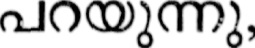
പറയുന്നു,
